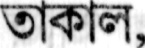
তাকাল,
